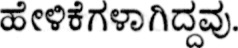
ಹೇಳಿಕೆಗಳಾಗಿದ್ದವು.
